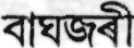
বাঘজৰী
